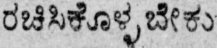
ರಚಿಸಿಕೊಳ್ಳಬೇಕು
